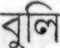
বুলি
